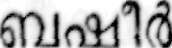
ബഷീര്‍
